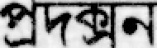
প্রদক্সন
